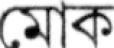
মোক
